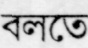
বলতে
